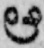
ಆ
